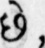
છે,
